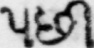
પછી
